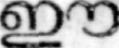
ഈ
